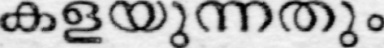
കളയുന്നതും
